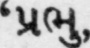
'પ્રભુ,
